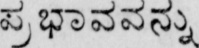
ಪ್ರಭಾವವನ್ನು
